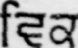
ਵਿਕ
